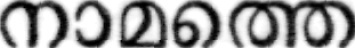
നാമത്തെ
